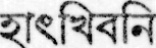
হাৎখিবনি
